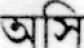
অসি
